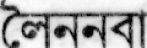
লৈননবা
